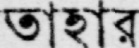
তাহার
